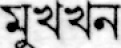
মুখখন
